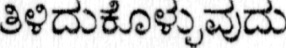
ತಿಳಿದುಕೊಳ್ಳುವುದು
